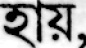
হায়,
